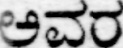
ಅವರ
